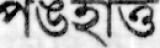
পঙহাত্ত
